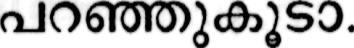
പറഞ്ഞുകൂടാ.
